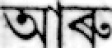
আৰু
